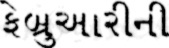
ફેબ્રુઆરીની
